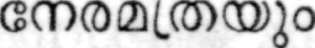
നേരമത്രയും
